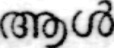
ആള്‍
